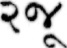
રજૂ
